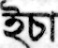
ইচা
